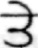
ਤੇ
